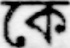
কে
